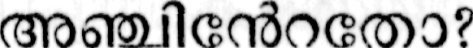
അഞ്ചിന്റേതോ?
